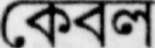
কেবল
